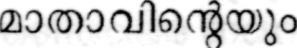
മാതാവിന്റെയും
